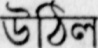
উঠিল
